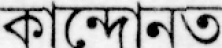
কান্দোনত
